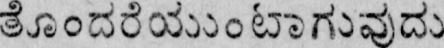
ತೊಂದರೆಯುಂಟಾಗುವುದು
